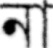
না
